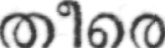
തീരെ
